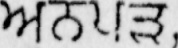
ਅਨਪੜ,
